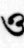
ও
